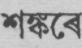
শঙ্কৰে
